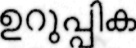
ഉറുപ്പിക
